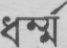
ধৰ্ম্ম
